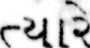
ત્યારે
